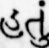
હતું
